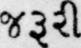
જરૂરી
